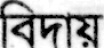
বিদায়
